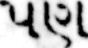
પણ
